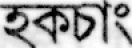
হকচাং
